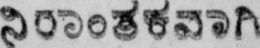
ನಿರಾಂತಕವಾಗಿ
